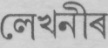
লেখনীৰ
